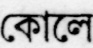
কোলে
